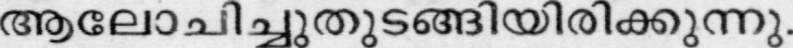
ആലോചിച്ചുതുടങ്ങിയിരിക്കുന്നു.
